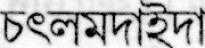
চৎলমদাইদা
